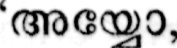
‘അയ്യോ,
